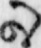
જે
